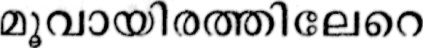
മൂവായിരത്തിലേറെ
